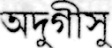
অদুগীসু
